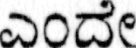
ಎಂದೇ
